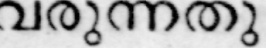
വരുന്നതു
